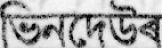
ভিনদেউৰ
